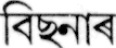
বিছনাৰ
